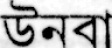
উনবা
